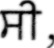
ਸੀ,
